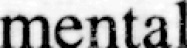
mental
